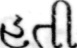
હતી
